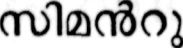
സിമന്റു
